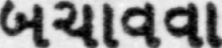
બચાવવા
